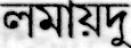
লমায়দু
